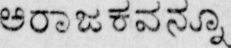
ಅರಾಜಕವನ್ನೂ
